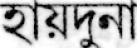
হায়দুনা
